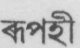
ৰূপহী
